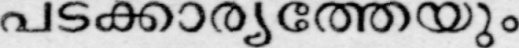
പടക്കാര്യത്തേയും
